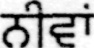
ਨੀਵਾਂ
